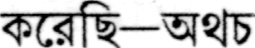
করেছি–অথচ
